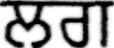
ਲਗ
